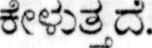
ಕೇಳುತ್ತದೆ.
